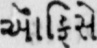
ઑફિસે
